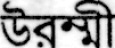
উরম্মী
